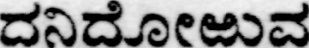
ದನಿದೋಱುವ
